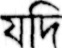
যদি
